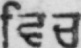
ਵਿਚ
